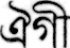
ঐগী
